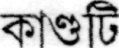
কাণ্ডটি
